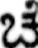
ಚೆ
